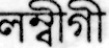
লম্বীগী
